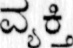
ವ್ಯಕ್ತಿ
